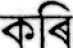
কৰি
